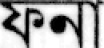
ফনা
